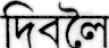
দিবলৈ
